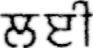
ਲਈ
